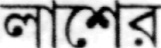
লাশের
